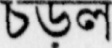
চড়ল
